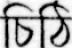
চিঠি
